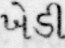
ખેડી
